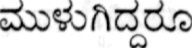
ಮುಳುಗಿದ್ದರೂ
